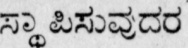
ಸ್ಥಾಪಿಸುವುದರ
